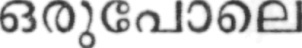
ഒരുപോലെ
